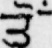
ਤੋਂ
